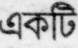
একটি
